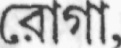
রোগা,
